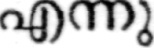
എന്നു
